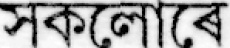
সকলোৰে
